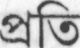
প্রতি
